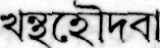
খন্থহৌদবা
